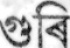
গুৰি
